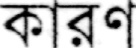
কারণ
